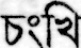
চংখি
